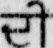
ਦੀ
